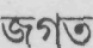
জগত
